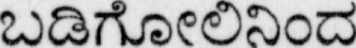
ಬಡಿಗೋಲಿನಿಂದ
